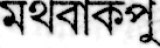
মথবাকপু
